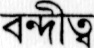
বন্দীত্ব
